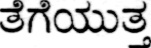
ತೆಗೆಯುತ್ತ
